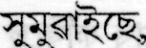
সুমুৱাইছে,
